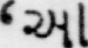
'આ
